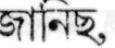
জানিছ,
